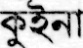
কুইনা
